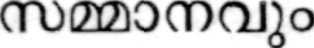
സമ്മാനവും
